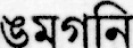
ঙমগনি
